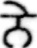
ਨੇ
